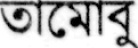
তামোবু
